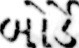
બોર્ડે
